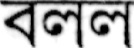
বলল
